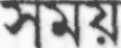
সময়
